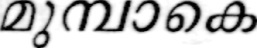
മുമ്പാകെ
